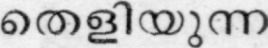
തെളിയുന്ന
